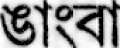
ঙাংবা
